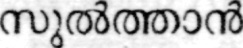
സുല്‍ത്താന്‍
